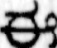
ಈ
